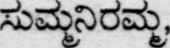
ಸುಮ್ಮನಿರಮ್ಮ,
